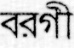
বরগী
